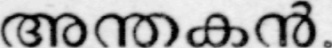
അന്തകന്‍.
